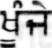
ਖੂੰਜੇ
